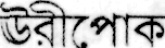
ঊরীপোক
